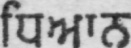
ਧਿਆਨ
